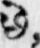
છે,
